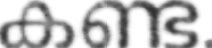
കണ്ട.
